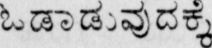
ಒಡಾಡುವುದಕ್ಕೆ
